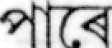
পাৰে
